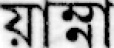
য়াম্না
